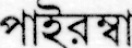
পাইরম্বা
